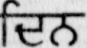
ਦਿਨ
